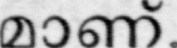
മാണ്.
